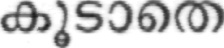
കൂടാതെ
